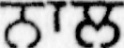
ਨਾਲ
